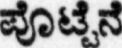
ಪೊಟ್ಟೆನೆ
